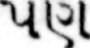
પણ
